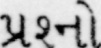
પ્રશ્નો
